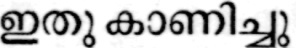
ഇതു കാണിച്ചു.
